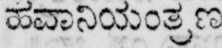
ಹವಾನಿಯಂತ್ರಣ
